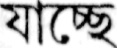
যাচ্ছে
